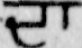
ਦਾ
